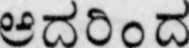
ಅದರಿಂದ
